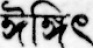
ঈঙ্গিৎ
